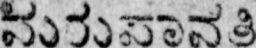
ಮರುಪಾವತಿ
